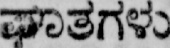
ಘಾತಗಳು
